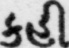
કહી
